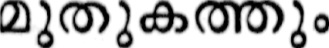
മുതുകത്തും
